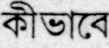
কীভাবে
